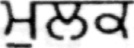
ਮੁਲਕ
